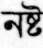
নষ্ট
